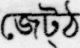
জেট্ঠ
